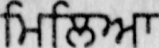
ਮਿਲਿਆ
